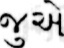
જુએ
